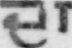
ਦਾ
